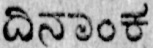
ದಿನಾಂಕ
